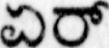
ಏರ್
